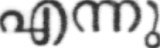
എന്നു
